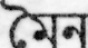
মৈন
